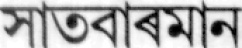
সাতবাৰমান
